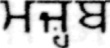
ਮਜ਼੍ਹਬ
